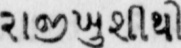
રાજીખુશીથી
